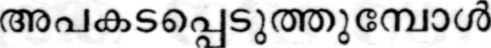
അപകടപ്പെടുത്തുമ്പോള്‍
